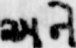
અને
